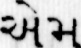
એમ
